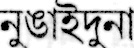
নুংঙাইদুনা
